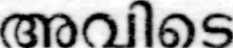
അവിടെ
